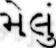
મેલું
